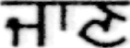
ਜਾਣ
